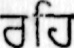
ਰਹਿ
